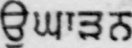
ਉਘਾੜਨ
